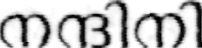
നന്ദിനി
